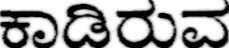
ಕಾಡಿರುವ
